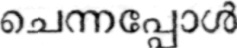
ചെന്നപ്പോള്‍
